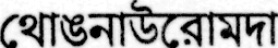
থোঙনাউরোমদা
